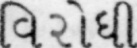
વિરોધી
